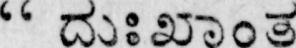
“ದುಃಖಾಂತ”
